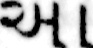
આ
